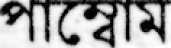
পাম্বোম
